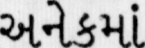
અનેકમાં
